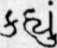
કહ્યું,
